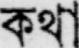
কথা
